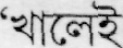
'খালেই
